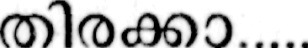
തിരക്കാ...
